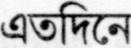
এতদিনে
